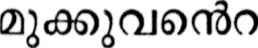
മുക്കുവന്റെ
